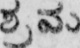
ಶ್ರಮ
